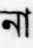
না
